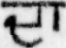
ਦਾ
